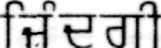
ਜ਼ਿੰਦਗੀ
